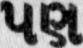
પણ
